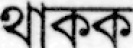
থাকক
